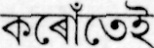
কৰোঁতেই
